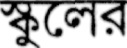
স্কুলের
